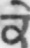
ਕੇ
